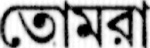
তোমরা
